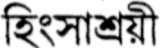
হিংসাশ্রয়ী
